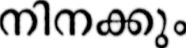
നിനക്കും
